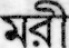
মরী
